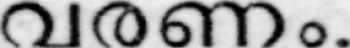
വരണം.
